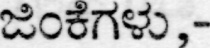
ಜಿಂಕೆಗಳು,-
